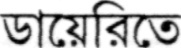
ডায়েরিতে
